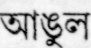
আঙুল
